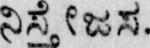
ನಿಸ್ತೇಜಸ.
